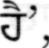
ਹੈ',
